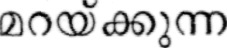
മറയ്ക്കുന്ന
